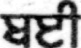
ਬਈ
